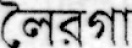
লৈরগা
